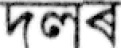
দলৰ
